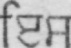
ਇਸ
